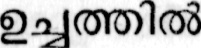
ഉച്ചത്തില്‍
